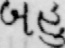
બહુ
